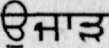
ਉਜਾੜ
